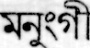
মনুংগী
